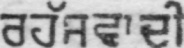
ਰਹੱਸਵਾਦੀ
